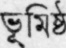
ভূমিষ্ঠ
